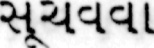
સૂચવવા
